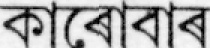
কাৰোবাৰ
